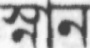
স্নান
